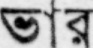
ভার
